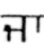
ਜਾ
